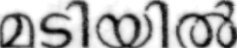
മടിയില്‍
